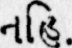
નહિ.
